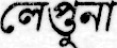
লেপ্তুনা
